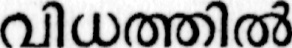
വിധത്തില്‍
